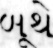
બૂથે
